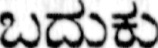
ಬದುಕು
